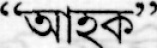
"আহক"
